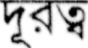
দূরত্ব
